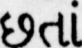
છતાં
